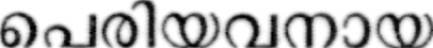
പെരിയവനായ
